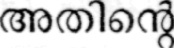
അതിന്റെ
